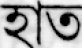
হাত
